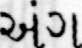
અંગ
